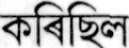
কৰিছিল
